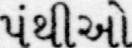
પંથીઓ
